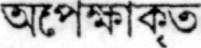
অপেক্ষাকৃত
